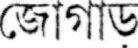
জোগাড়
